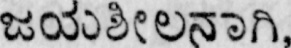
ಜಯಶೀಲನಾಗಿ,
